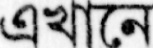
এখানে
